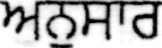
ਅਨੁਸਾਰ
